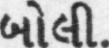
બોલી.
